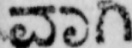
ವಾಗಿ
